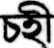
চহী
